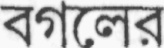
বগলের
